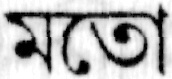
মতো
